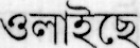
ওলাইছে
